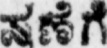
ಷಣೆಗೆ
